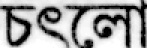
চৎলো
